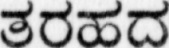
ತರಹದ
